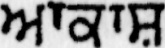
ਆਕਾਸ਼
